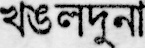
খঙলদুনা
